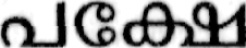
പക്ഷേ
